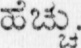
ಹೆಚ್ಚು.
